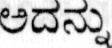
ಅದನ್ನು
